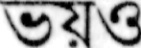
ভয়ও
